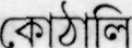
কোঠালি
